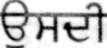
ਉਸਦੀ
